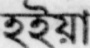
হইয়া
